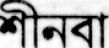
শীনবা
